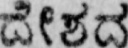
ದೇಶದ
